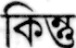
কিন্তু
